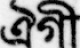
ঐগী
